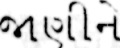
જાણીને
